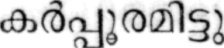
കര്‍പ്പൂരമിട്ടു
